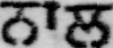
ਨਾਲ
